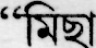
"মিছা
